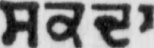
ਸਕਦਾ
